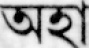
অহা
